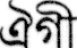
ঐগী
